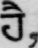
ਹੈ,
